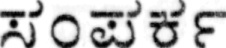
ಸಂಪರ್ಕ
